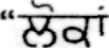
''ਲੋਕਾਂ
